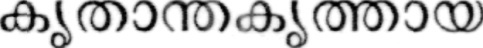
കൃതാന്തകൃത്തായ
